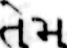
તેમ
